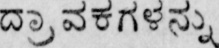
ದ್ರಾವಕಗಳನ್ನು
